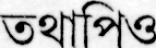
তথাপিও
